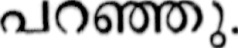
പറഞ്ഞു.
